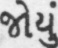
જોયું
